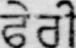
ਫੇਰੀ
